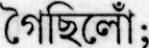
গৈছিলোঁ;
